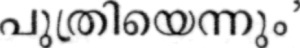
പുത്രിയെന്നും'
